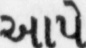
આપે
